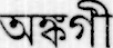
অঙ্কগী
